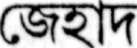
জেহাদ
